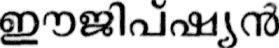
ഈജിപ്ഷ്യന്‍
